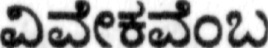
ವಿವೇಕವೆ೦ಬ
